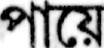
পায়ে
